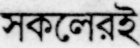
সকলেরই
